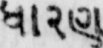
ધારણ
